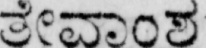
ತೇವಾಂಶ
